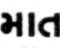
માત
